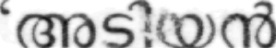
'അടിയന്‍
